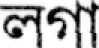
লগা
